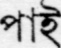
পাই
